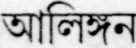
আলিঙ্গন
